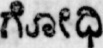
ಗೋಧಿ
